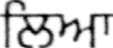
ਲਿਆ
